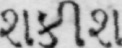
શકીશ
